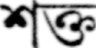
শক্ত
